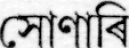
সোণাৰি
